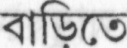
বাড়িতে
